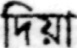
দিয়া
